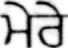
ਮੇਰੇ
